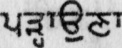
ਪੜ੍ਹਾਉਣਾ
